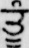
ਤੂੰ
